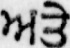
ਅਤੇ
